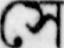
সে
